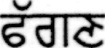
ਫੱਗਣ
